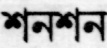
শনশন
